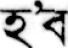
হ'ব
